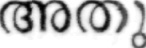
അതു
